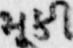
મૂકી
